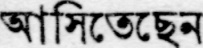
আসিতেছেন
